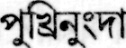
পুখ্রিনুংদা
